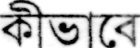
কীভাবে
